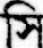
সি
